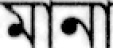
মানা
